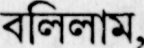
বলিলাম,
